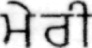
ਮੇਰੀ
